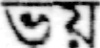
ভয়
